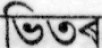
ভিতৰ
